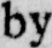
by
